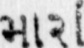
મારાં
